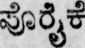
ಪೊರೈಕೆ
